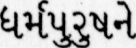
ધર્મપુરુષને
